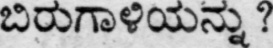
ಬಿರುಗಾಳಿಯನ್ನು?
